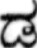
ಡ
